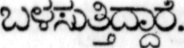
ಬಳುಸುತ್ತಿದ್ದಾರೆ.
